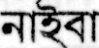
নাইবা
